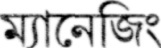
ম্যানেজিং
